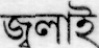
জ্বলাই
